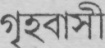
গৃহবাসী
